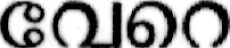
വേറെ
